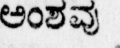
ಅಂಶವು
